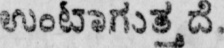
ಉಂಟಾಗುತ್ತದೆ.
